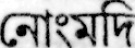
নোংমদি
